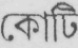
কোটি
